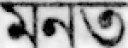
মনত
